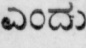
ಎಂದು
